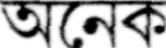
অনেক
